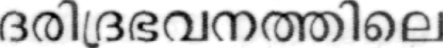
ദരിദ്രഭവനത്തിലെ
